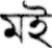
মই
